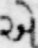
એ
